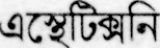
এস্থেটিক্সনি
